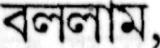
বললাম,
